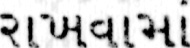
રાખવામાં
